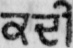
ਕਦੀ
